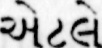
એટલે
